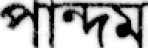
পান্দম
